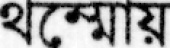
থম্মোয়
